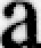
a
